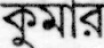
কুমার
